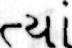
ત્યાં
